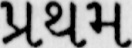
પ્રથમ
